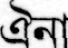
ঐনা
